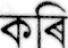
কৰি
